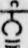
ਨੂੰ
